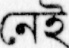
নেই
